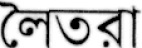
লৈতরা
